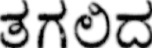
ತಗಲಿದ
